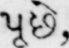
પૂછે,
